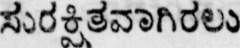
ಸುರಕ್ಷಿತವಾಗಿರಲು
